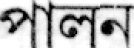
পালন
